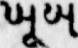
ખૂબ
